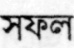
সফল
